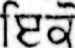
ਇਕੋ
